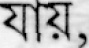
যায়,
